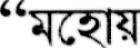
“মহোয়
